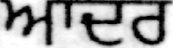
ਆਦਰ
